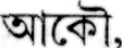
আকৌ,
